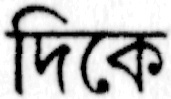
দিকে
